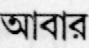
আবার
